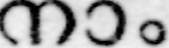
നാം
